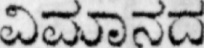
ವಿಮಾನದ
